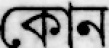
কোন
